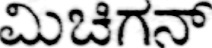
ಮಿಚಿಗನ್
